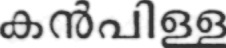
കന്‍പിള്ള
